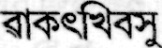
ৱাকৎখিবসু
